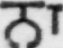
ਨਾ
